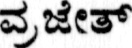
ವ್ರಜೇತ್
